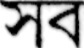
সব
